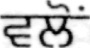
ਵਲੋਂ
